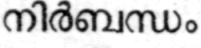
നിര്‍ബന്ധം
